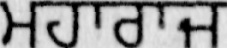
ਮਹਾਰਾਜ
